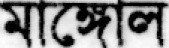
মাঙ্গোল
